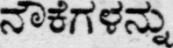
ನೌಕೆಗಳನ್ನು
